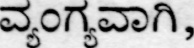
ವ್ಯಂಗ್ಯವಾಗಿ,
